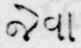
જેવા
